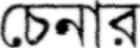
চেনার
